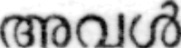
അവള്‍
